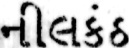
નીલકંઠ
